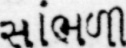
સાંભળી
